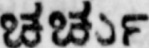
ಚರ್ಚು
